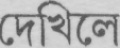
দেখিলে
